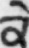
ਕੇ
